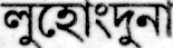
লুহোংদুনা
